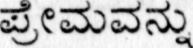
ಪ್ರೇಮವನ್ನು
